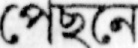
পেছনে
